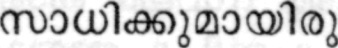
സാധിക്കുമായിരു
